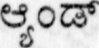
ಅಂಡ್
